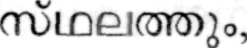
സ്ഥലത്തും,
